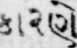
કારણે
